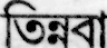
তিন্নবা
